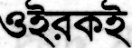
ওইরকই
